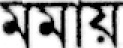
মমায়
